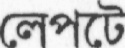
লেপটে
